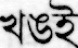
খঙই
